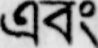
এবং
